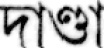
দাণ্ডা
